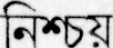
নিশ্চয়
